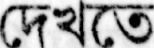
দেখতে
